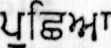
ਪੁਛਿਆ
